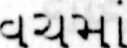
વચમાં
